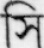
সি
